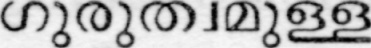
ഗുരുത്വമുള്ള
